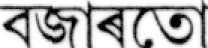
বজাৰতো
